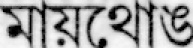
মায়থোঙ
